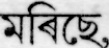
মৰিছে,
